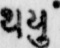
થયું
